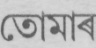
তোমাৰ
